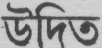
উদিত
